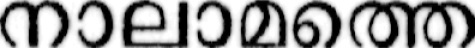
നാലാമത്തെ
